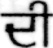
ਦੀ
